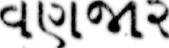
વણજાર
